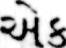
એક
